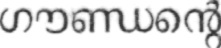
ഗൗണ്ഡന്റെ
